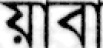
য়াবা
